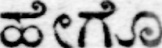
ಹೇಗೊ
